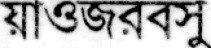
য়াওজরবসু
